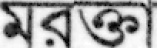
মরক্তা
